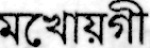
মখোয়গী
